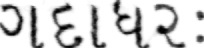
ગદાધરઃ
